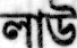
লাউ
